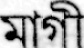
মাগী
